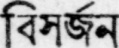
বিসর্জন
